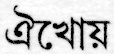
ঐখোয়
